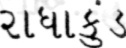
રાધાકુંડ
